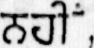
ਨਹੀਂ,
